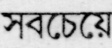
সবচেয়ে
